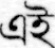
এই
